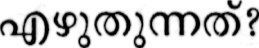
എഴുതുന്നത്?
